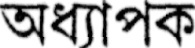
অধ্যাপক
